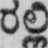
ರಲ್ಲಿ
